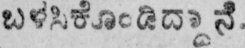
ಬಳಸಿಕೊಂಡಿದ್ದಾನೆ.
